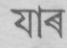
যাৰ
